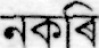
নকৰি
